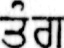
ਤੰਗ
